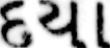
દયા
